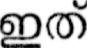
ഇത്
